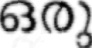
ഒരു
